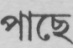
পাছে
